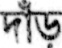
দাঁড়
